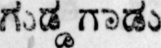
ಗುಡ್ಡಗಾಡು
